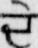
ਦੇ
